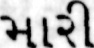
મારી
